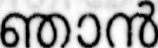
ഞാന്‍
